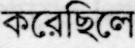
করেছিলে
